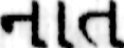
નાત
